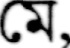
মে,
